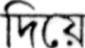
দিয়ে
